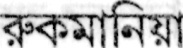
রুকমানিয়া
